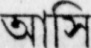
আসি
